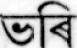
ভৰি
